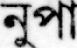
নুপা
